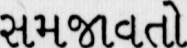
સમજાવતો
